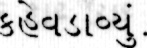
કહેવડાવ્યું.
